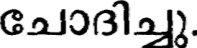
ചോദിച്ചു.
